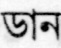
ডান
